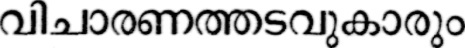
വിചാരണത്തടവുകാരും
